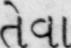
તેવા
